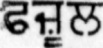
ਫ਼ਜ਼ੂਲ
